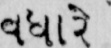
વધારે
